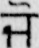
ਜੋ
